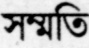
সম্মতি
